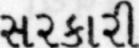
સરકારી
